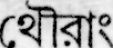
থৌরাং
